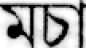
মচা
